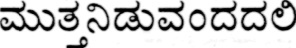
ಮುತ್ತನಿಡುವಂದದಲಿ
